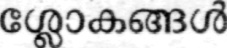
ശ്ലോകങ്ങള്‍
